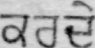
ਕਰਦੇ
